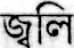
জ্বলি
